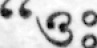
“ওঃ
